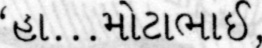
'હા...મોટાભાઈ,
